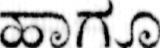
ಹಾಗೂ
